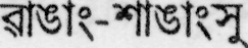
রাঙাং-শাঙাংসু
